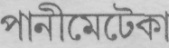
পানীমেটেকা
